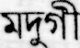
মদুগী
